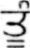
ਤੂੰ
